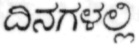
ದಿನಗಳಲ್ಲಿ
